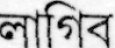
লাগিব
